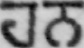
ਹਨ
